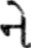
ને
